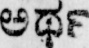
ಅರ್ಥ
